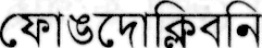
ফোঙদোক্লিবনি
